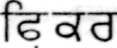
ਫ਼ਿਕਰ
